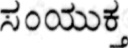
ಸಂಯುಕ್ತ
